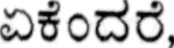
ಏಕೆಂದರೆ,
